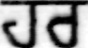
ਹਰ
